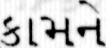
કામને
